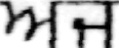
ਅਜ
